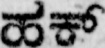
ಹಕ್
